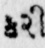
કરી
